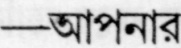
–আপনার
